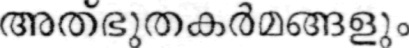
അത്ഭുതകര്‍മങ്ങളും
